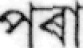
পৰা
